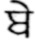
ਬੇ
